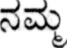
ನಮ್ಮ
